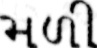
મળી
